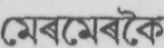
মেৰমেৰকৈ
